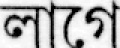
লাগে
